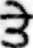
ਤੇ
